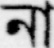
না
